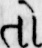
તો
